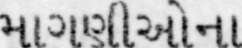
માગણીઓના
